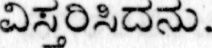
ವಿಸ್ತರಿಸಿದನು.
